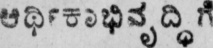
ಆರ್ಥಿಕಾಭಿವೃದ್ಧಿಗೆ
